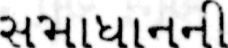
સમાધાનની
